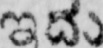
ಇದು
